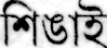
শিঙাই
